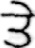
ਤੇ
